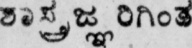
ಶಾಸ್ತ್ರಜ್ಞರಿಗಿಂತ
